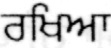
ਰਖਿਆ
